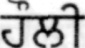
ਹੌਲੀ
